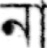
না
